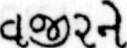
વજીરને
